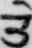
ਤੇ
